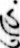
હું
